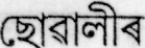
ছোৱালীৰ
